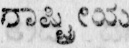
ರಾಷ್ಟ್ರೀಯ
